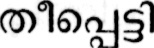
തീപ്പെട്ടി
